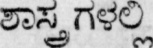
ಶಾಸ್ತ್ರಗಳಲ್ಲಿ
